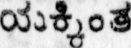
ಯಕ್ಕಿಂತ
